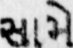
સામે
